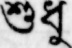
শুধু
